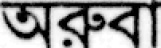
অরুবা
